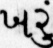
ખરું
